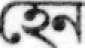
হেন
